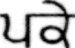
ਪਕੇ
